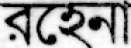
রহেনা
